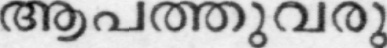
ആപത്തുവരു
